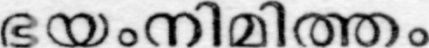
ഭയംനിമിത്തം
